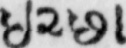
ઇચ્છા
